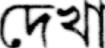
দেখা
